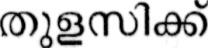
തുളസിക്ക്
